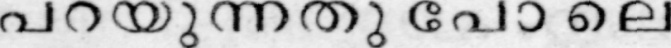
പറയുന്നതുപോലെ
